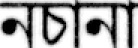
নচানা
